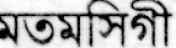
মতমসিগী
